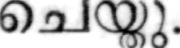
ചെയ്തു.
